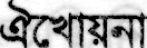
ঐখোয়না
